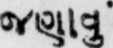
જણાવું
